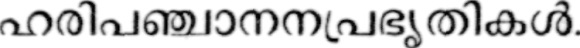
ഹരിപഞ്ചാനനപ്രഭൃതികള്‍.
